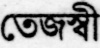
তেজস্বী
